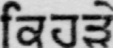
ਕਿਹੜੇ
